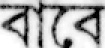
বাবে
